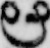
ಆ
